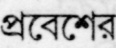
প্রবেশের
